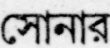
সোনার
